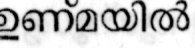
ഉണ്മയില്‍
